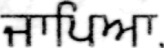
ਜਾਪਿਆ,
